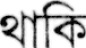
থাকি
